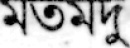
মতমদু
